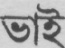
ভাই
